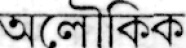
অলৌকিক
